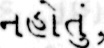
નહોતું,
